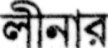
লীনার
